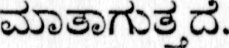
ಮಾತಾಗುತ್ತದೆ.
